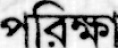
পরিক্ষা
